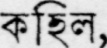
কহিল,
